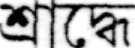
শ্রাদ্ধে
